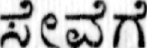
ಸೇವೆಗೆ
